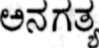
ಅನಗತ್ಯ
